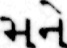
મને
